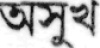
অসুখ
